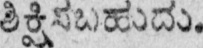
ಶಿಕ್ಷಿಸಬಹುದು.
